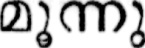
മൂന്നു
